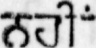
ਨਹੀਂ
